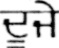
ਦੂਜੇ
